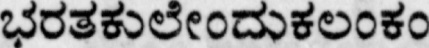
ಭರತಕುಲೇಂದುಕಲಂಕಂ
